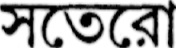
সতেরো
